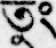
তুং
